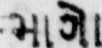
માગો
